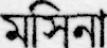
মসিনা
